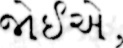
જોઈએ,
